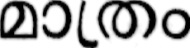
മാത്രം
